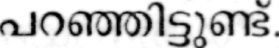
പറഞ്ഞിട്ടുണ്ട്.
